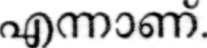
എന്നാണ്.
